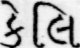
કેલિ
